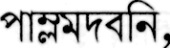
পাম্লমদবনি,
